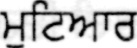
ਮੁਟਿਆਰ
